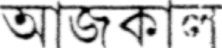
আজকাল
